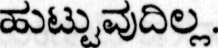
ಹುಟ್ಟುವುದಿಲ್ಲ.
